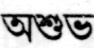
অশুভ
